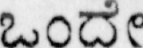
ಒಂದೇ
